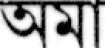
অমা
